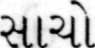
સાચો
